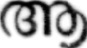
ആ
